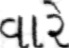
વારે
